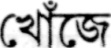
খোঁজে
